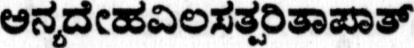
ಅನ್ಯದೇಹವಿಲಸತ್ಪರಿತಾಪಾತ್
